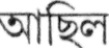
আছিল
